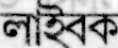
লাইবক
